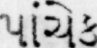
પાંચેક
